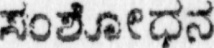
ಸಂಶೋಧನ
